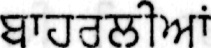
ਬਾਹਰਲੀਆਂ
